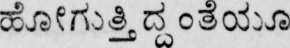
ಹೋಗುತ್ತಿದ್ದಂತೆಯೂ
